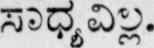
ಸಾಧ್ಯವಿಲ್ಲ.
